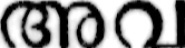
അവ
